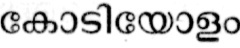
കോടിയോളം
